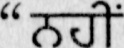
''ਨਹੀਂ
